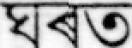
ঘৰত
